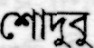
শোদুবু
